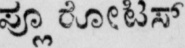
ಪ್ಲೂರೋಟಿಸ್
